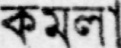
কমলা
